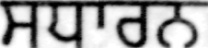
ਸਧਾਰਨ
